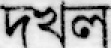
দখল
